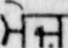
ਮੇਜ਼
